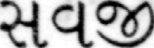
સવજી
